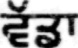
ਵੱਡਾ
